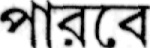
পারবে
